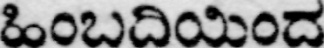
ಹಿಂಬದಿಯಿಂದ
